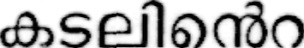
കടലിന്റെ
